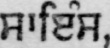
ਸਾਇੰਸ,
